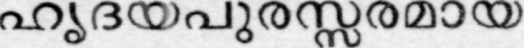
ഹൃദയപുരസ്സരമായ
